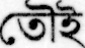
তৌই
